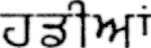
ਹਡੀਆਂ
